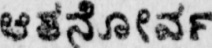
ಆತನೋರ್ವ
